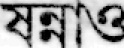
ষন্নাও
